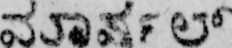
ಮಾರ್ಷಲ್
